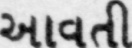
આવતી
